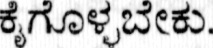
ಕೈಗೊಳ್ಳಬೇಕು.
